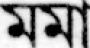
মমা
